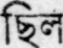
ছিল
